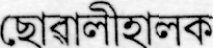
ছোৱালীহালক
